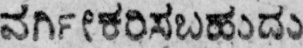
ವರ್ಗೀಕರಿಸಬಹುದು
